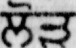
ਲੋੜ
